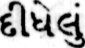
દીધેલું
